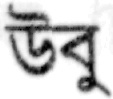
উবু
